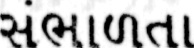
સંભાળતા
